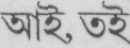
আই,তই
